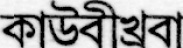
কাউবীখ্রবা
